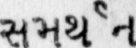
સમર્થન
